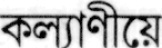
কল্যাণীয়ে
